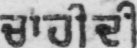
ਚਾਹੀਦੀ
